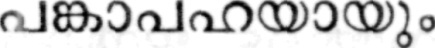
പങ്കാപഹയായും
